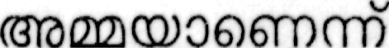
അമ്മയാണെന്ന്
